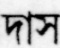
দাস
